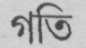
গতি
